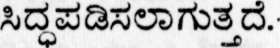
ಸಿದ್ಧಪಡಿಸಲಾಗುತ್ತದೆ.
